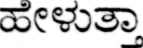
ಹೇಳುತ್ತಾ
